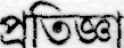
প্রতিজ্ঞা
